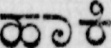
ಹಾಕಿ
